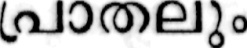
പ്രാതലും
